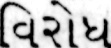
વિરોધ
